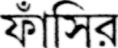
ফাঁসির
